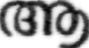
ആ
